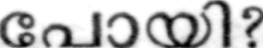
പോയി?
